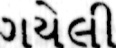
ગયેલી
